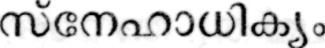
സ്നേഹാധിക്യം
